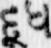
દૂધ
